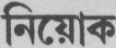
নিয়োক
